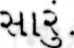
સારું.
